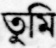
তুমি
